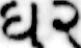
ઘર
